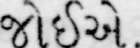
જોઈએ.
